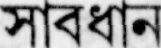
সাবধান
